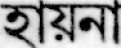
হায়না
